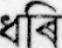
ধৰি
